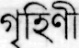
গৃহিণী
